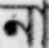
না
